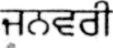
ਜਨਵਰੀ
